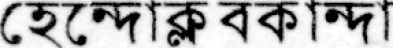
হেন্দোক্লবকান্দা
